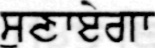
ਸੁਣਾਏਗਾ
